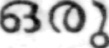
ഒരു
